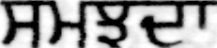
ਸਮਝਦਾ
